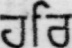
ਹਰਿ
